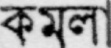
কমলা
